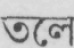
তলে
